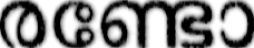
രണ്ടോ
